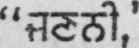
''ਜਣਨੀ,''
